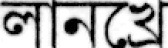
লানখ্রে
